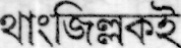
থাংজিল্লকই
